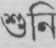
শুনি
